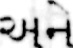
અને
